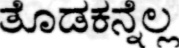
ತೊಡಕನ್ನೆಲ್ಲ
